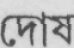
দোষ
